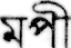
মপী
